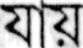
যায়
